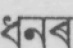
ধনৰ
